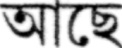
আছে
